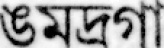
ঙমদ্রগা
